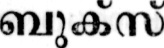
ബുക്സ്
